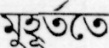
মুহূর্ততে
